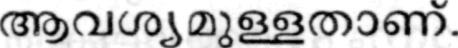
ആവശ്യമുള്ളതാണ്.
